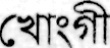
খোংগী
